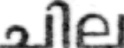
ചില
